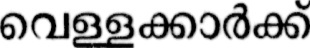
വെള്ളക്കാര്‍ക്ക്
